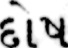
દોષ
